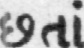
છતાં
